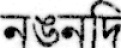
নঙনদি
